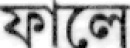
ফালে
